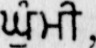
ਘੁੰਮੀ,
